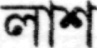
লাশ
